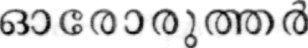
ഓരോരുത്തര്‍
